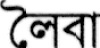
লৈবা
